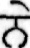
ਨੇ
